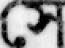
সে
